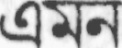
এমন
